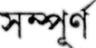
সম্পূর্ণ
